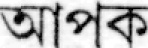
আপক
